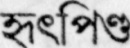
হৃৎপিণ্ড
